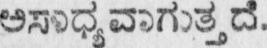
ಅಸಾಧ್ಯವಾಗುತ್ತದೆ.
